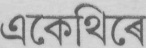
একেথিৰে
